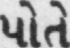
પોતે
